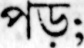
পড়;
